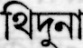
থিদুনা
